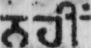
ਨਹੀਂ
